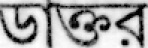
ডাক্তর
